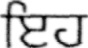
ਇਹ
